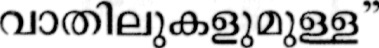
വാതിലുകളുമുള്ള”
